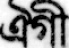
ঐগী
